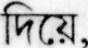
দিয়ে,
